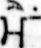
ਮੈਂ
